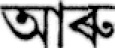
আৰু
